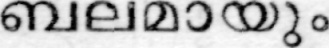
ബലമായും
